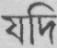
যদি
